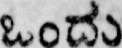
ಒಂದು
